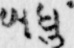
બધું
